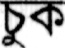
চুক
